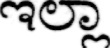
ಇಲ್ಲಾ
